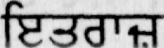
ਇਤਰਾਜ਼
